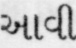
આવી
